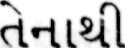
તેનાથી
